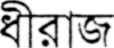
ধীরাজ
